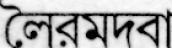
লৈরমদবা
